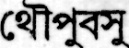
থৌপুবসু
